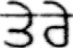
ਤੇਰੇ
